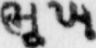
ભૂખ
